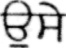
ਉਸੇ
